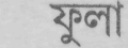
ফুলা
